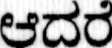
ಆದರೆ
